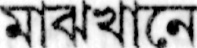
মাঝখানে
